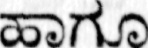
ಹಾಗೂ
